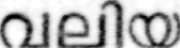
വലിയ
